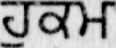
ਹੁਕਮ
